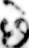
છે
